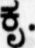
ಕೃ.
